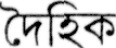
দৈহিক
